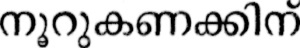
നൂറുകണക്കിന്
